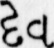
દેવ
